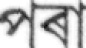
পৰা
